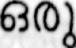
ഒരു
